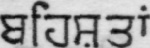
ਬਹਿਸ਼ਤਾਂ
